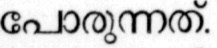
പോരുന്നത്.
